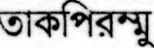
তাকপিরম্মু
